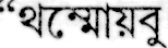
“থম্মোয়বু
